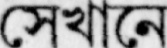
সেখানে
